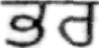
ਭਰ
